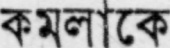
কমলাকে
